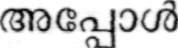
അപ്പോള്‍
